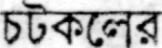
চটকলের
